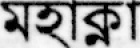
মহাক্না
